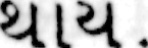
થાય.
